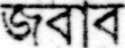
জবাব
